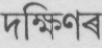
দক্ষিণৰ
